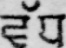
ਵੱਧ
